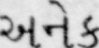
અનેક
